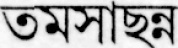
তমসাছন্ন
